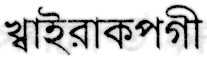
খ্বাইরাকপগী
